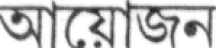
আয়োজন
